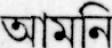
আমনি
